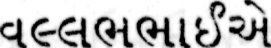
વલ્લભભાઈએ
